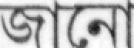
জানো
